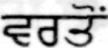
ਵਰਤੋਂ
